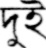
দুই
